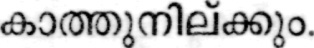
കാത്തുനില്ക്കും.
